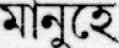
মানুহে
